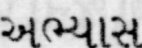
અભ્યાસ
